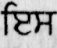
ਇਸ
